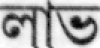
লাভ
